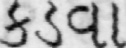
કડવા
